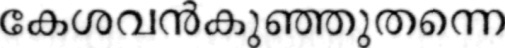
കേശവന്‍കുഞ്ഞുതന്നെ
